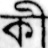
কী
